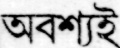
অবশ্যই
